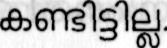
കണ്ടിട്ടില്ല.
